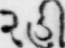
રહી
